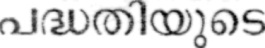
പദ്ധതിയുടെ
